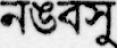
নঙবসু
